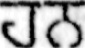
ਹਨ
